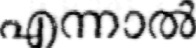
എന്നാല്‍
